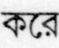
করে
